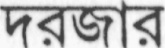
দরজার
